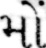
મોં
